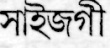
সাইজগী
